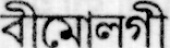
বীমোলগী
